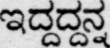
ಇದ್ದದ್ದನ್ನ
